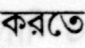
করতে
